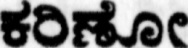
ಕರಿಣೋ
